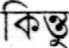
কিন্তু
